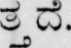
ತ್ತದೆ.
